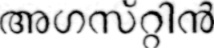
അഗസ്റ്റിന്‍
